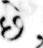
છે,
